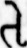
તે
